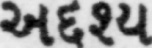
અદ્દશ્ય
